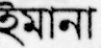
ইমানা
